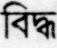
বিদ্ধ
